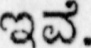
ಇವೆ.
